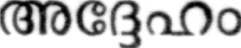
അദ്ദേഹം
